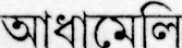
আধামেলি
